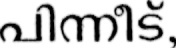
പിന്നീട്,
